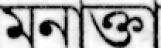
মনাক্তা
